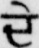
ਦੇ
